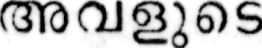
അവളുടെ
